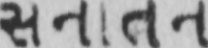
સનાતન
